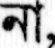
না,
